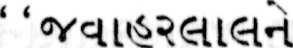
"જવાહરલાલને
